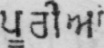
ਪੂਰੀਆਂ
